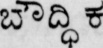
ಬೌದ್ಧಿಕ
